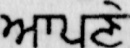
ਆਪਣੇ
